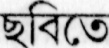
ছবিতে
